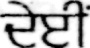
ਦੇਈਂ
